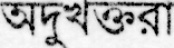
অদুখক্তরা
